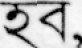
হব,
